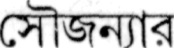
সৌজন্যার
